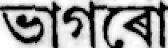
ভাগৰো
